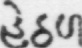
હેઠળ
